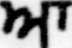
ਆ
